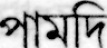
পামদি
